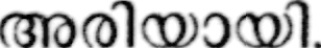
അരിയായി.
